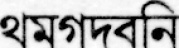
থমগদবনি
